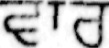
ਵਾਰ
